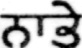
ਨਾਭੇ
